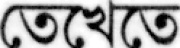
তেখেতে
